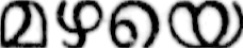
മഴയെ
